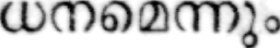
ധനമെന്നും
